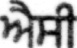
ਐਸੀ
